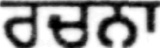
ਰਚਨਾ
